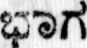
ಭಾಗ
